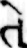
તે
